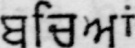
ਬਚਿਆਂ
